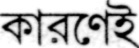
কারণেই
